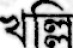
খল্লি
